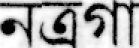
নত্রগা
